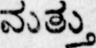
ಮತ್ತು
